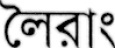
লৈরাং
